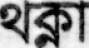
থক্না
